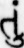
તું
